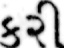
કરી
